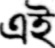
এই
